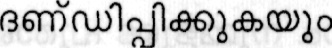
ദണ്ഡിപ്പിക്കുകയും
